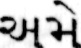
અમે
